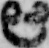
ಆ
